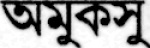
অমুকসু
